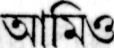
আমিও
